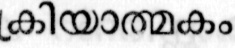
ക്രിയാത്മകം
